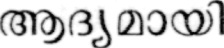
ആദ്യമായി
